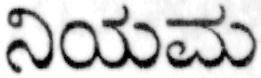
ನಿಯಮ
